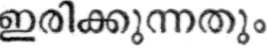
ഇരിക്കുന്നതും
